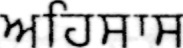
ਅਹਿਸਾਸ
